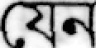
যেন
